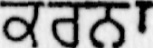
ਕਰਨਾ
